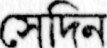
সেদিন
